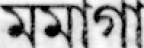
মমাগা
